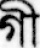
গী
